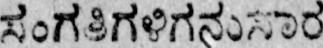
ಸಂಗತಿಗಳಿಗನುಸಾರ
